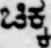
ಚಿಕ್ಕ
